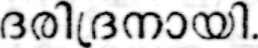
ദരിദ്രനായി.
